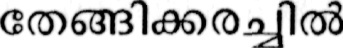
തേങ്ങിക്കരച്ചില്‍
